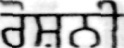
ਰੋਸ਼ਨੀ
